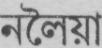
নলৈয়া
